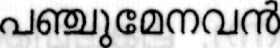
പഞ്ചുമേനവന്‍
